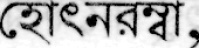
হোৎনরম্বা,
